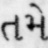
તમે
